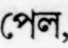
পেল,
